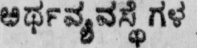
ಅರ್ಥವ್ಯವಸ್ಥೆಗಳ
